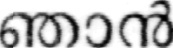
ഞാന്‍
